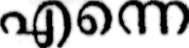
എന്നെ
